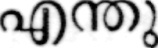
എന്തു
